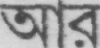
আর
